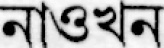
নাওখন
